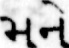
મને
